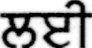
ਲਈ
